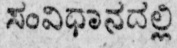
ಸಂವಿಧಾನದಲ್ಲಿ
